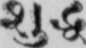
શુદ્ધ
